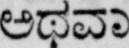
ಅಥವಾ
